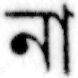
না
